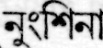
নুংশিনা
